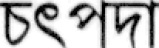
চৎপদা
